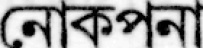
নোকপনা
